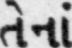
તેનાં
